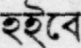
হইবে
